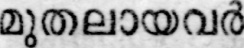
മുതലായവര്‍
